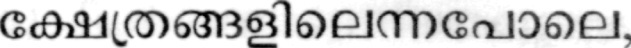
ക്ഷേത്രങ്ങളിലെന്നപോലെ,
